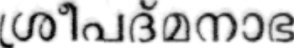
ശ്രീപദ്മനാഭ
